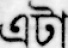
এটা
